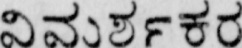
ವಿಮರ್ಶಕರ
